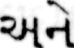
અને
